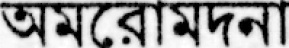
অমরোমদনা
